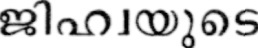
ജിഹ്വയുടെ
